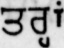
ਤਰ੍ਹਾਂ
